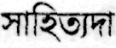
সাহিত্যদা
